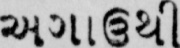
અગાઉથી
